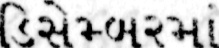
ડિસેમ્બરમાં
